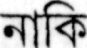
নাকি
